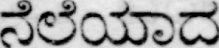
ನೆಲೆಯಾದ
